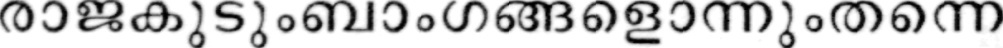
രാജകുടുംബാംഗങ്ങളൊന്നുംതന്നെ
